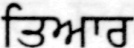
ਤਿਆਰ
